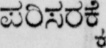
ಪರಿಸರಕ್ಕೆ
